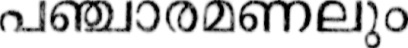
പഞ്ചാരമണലും
